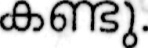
കണ്ടു.
